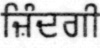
ਜ਼ਿੰਦਗੀ
